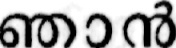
ഞാന്‍
